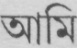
আমি
